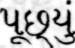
પૂછ્યું-
